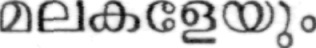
മലകളേയും
